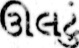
ઊલટું
